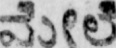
ಮೇಲೆ
